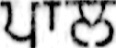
ਪਾਲ
